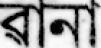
ৱানা
